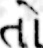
તો
